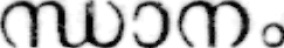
ന്ധാനം
